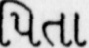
પિતા
